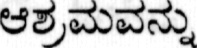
ಆಶ್ರಮವನ್ನು
